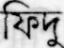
ফিদু
